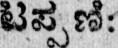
ಟಿಪ್ಪಣಿ
